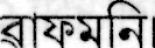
ৱাফমনি।
